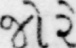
જોરે
